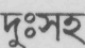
দুঃসহ
